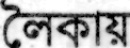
লৈকায়
